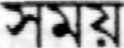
সময়
